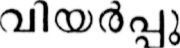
വിയര്‍പ്പു
